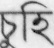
চুহি
